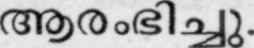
ആരംഭിച്ചു.
